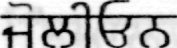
ਜੋਲੀਓਨ
